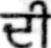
ਦੀ
